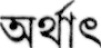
অর্থাৎ
